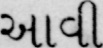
આવી
